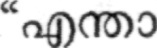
“എന്താ
